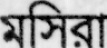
মসিরা
